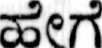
ಹೇಗೆ
